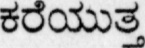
ಕರೆಯುತ್ತ
